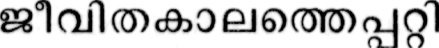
ജീവിതകാലത്തെപ്പറ്റി
